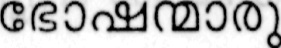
ഭോഷന്മാരു
